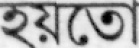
হয়তো
